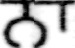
ਨਾ
